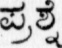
ಪ್ರಶ್ನೆ
